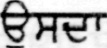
ਉਸਦਾ
